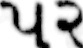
પર
